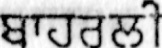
ਬਾਹਰਲੀ
